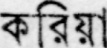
করিয়া
